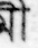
মী
